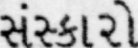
સંસ્કારો
